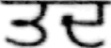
ਤਦ
